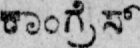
ಕಾಂಗ್ರೆಸ್
